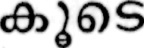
കൂടെ
